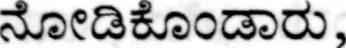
ನೋಡಿಕೊಂಡಾರು,
